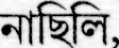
নাছিলি,
